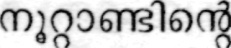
നൂറ്റാണ്ടിന്റെ
